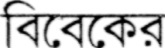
বিবেকের
